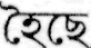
হৈছে
